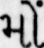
મોં
